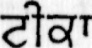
ਟੀਕਾ
